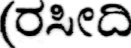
(ರಸೀದಿ
